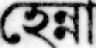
হেন্না
